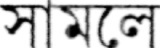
সামলে
